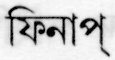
ফিনাপ্
